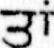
ਤਾਂ
